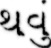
થવું
